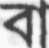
বা
